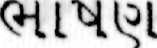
ભાષણ
